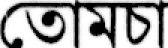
তোমচা
